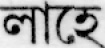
লাহে
